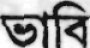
ভাবি
